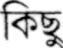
কিছু
